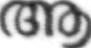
ആ
